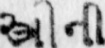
સ્ત્રીની
